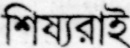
শিষ্যরাই
